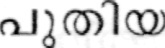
പുതിയ
